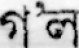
গ'ল
